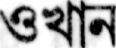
ওখান
